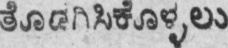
ತೊಡಗಿಸಿಕೊಳ್ಳಲು
